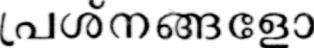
പ്രശ്നങ്ങളോ
